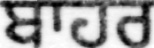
ਬਾਹਰ
